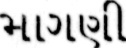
માગણી
